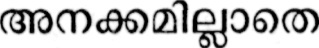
അനക്കമില്ലാതെ
